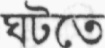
ঘটতে
